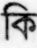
কি
